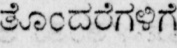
ತೊಂದರೆಗಳಿಗೆ
